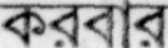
করবার
